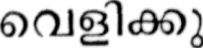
വെളിക്കു
